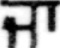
ਜਾ
